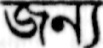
জন্য
